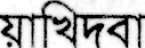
য়াখিদবা
